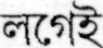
লগেই
